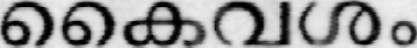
കൈവശം
